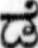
ಡೆ
